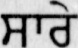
ਸਾਰੇ
